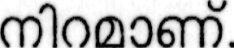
നിറമാണ്.
